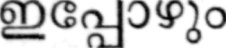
ഇപ്പോഴും
